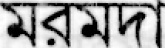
মরমদা
